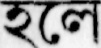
হলে
